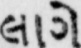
લાગે
